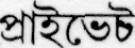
প্রাইভেট
